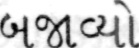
બજાવ્યો
